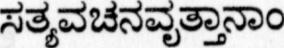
ಸತ್ಯವಚನವೃತ್ತಾನಾಂ
